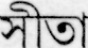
সীতা
